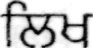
ਲਿਖ
